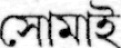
সোমাই
